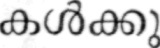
കള്‍ക്കു
